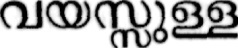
വയസ്സുള്ള
